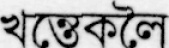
খন্তেকলৈ
